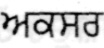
ਅਕਸਰ
